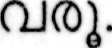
വരൂ.
